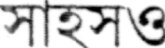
সাহসও
